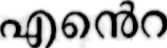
എന്റെ
